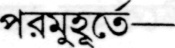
পরমুহূর্তে-
